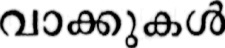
വാക്കുകള്‍
